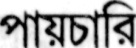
পায়চারি
